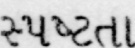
સ્પષ્ટતા
